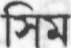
সিম
